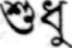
শুধু
